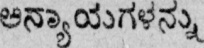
ಅನ್ಯಾಯಗಳನ್ನು
